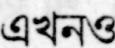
এখনও
